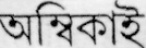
অম্বিকাই
